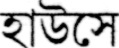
হাউসে
